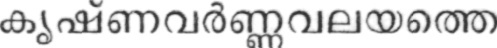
കൃഷ്ണവര്‍ണ്ണവലയത്തെ
